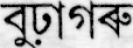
বুঢ়াগৰু
